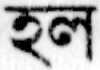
হল
